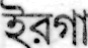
ইরগা
